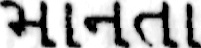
માનતા
